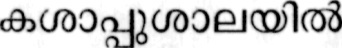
കശാപ്പുശാലയില്‍
